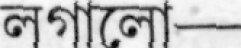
লগালো-
